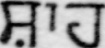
ਸ਼ਾਹ
